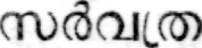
സര്‍വത്ര
